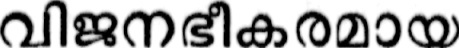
വിജനഭീകരമായ
